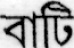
বাটি
